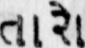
તારો
